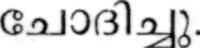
ചോദിച്ചു.
